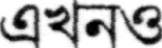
এখনও
